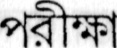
পরীক্ষা
